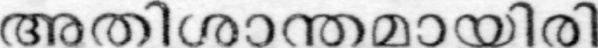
അതിശാന്തമായിരി
